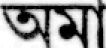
অমা
